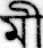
মী
